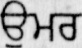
ਉਮਰ
